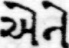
એને
